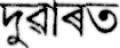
দুৱাৰত
